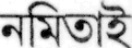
নমিতাই
